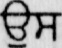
ਉਸ
